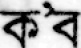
ক'ব
